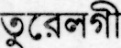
তুরেলগী
